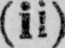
(ii)
